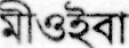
মীওইবা
